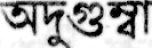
অদুগুম্বা
